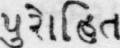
પુરોહિત
